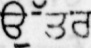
ਉੱਤਰ
